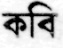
কবি
